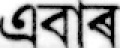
এবাৰ
